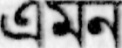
এমন
